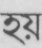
হয়
